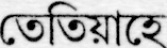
তেতিয়াহে
